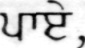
ਪਾਏ,
